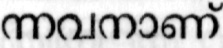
ന്നവനാണ്
